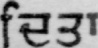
ਦਿਤਾ
